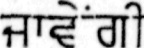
ਜਾਵੇਂਗੀ
